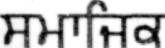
ਸਮਾਜਿਕ
